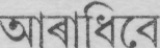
আৰাধিবে
